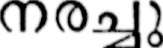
നരച്ചു
